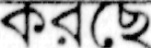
করছে
